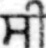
ਸੀ
